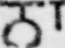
ਨਾ
